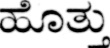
ಹೊತ್ತು
